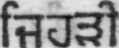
ਜਿਹੜੀ
